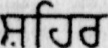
ਸ਼ਹਿਰ
